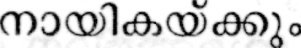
നായികയ്ക്കും
